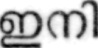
ഇനി
